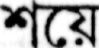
শয়ে
